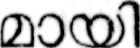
മായി
